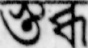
স্তব্ধ
